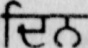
ਦਿਨ
